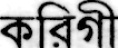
করিগী
